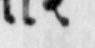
માર
